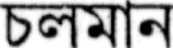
চলমান
